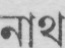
নাথ
